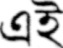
এই
